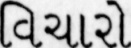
વિચારો
